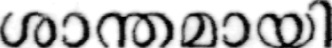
ശാന്തമായി
